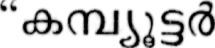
"കമ്പ്യൂട്ടര്‍
